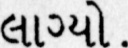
લાગ્યો.
